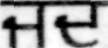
ਜਦ
